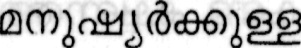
മനുഷ്യര്‍ക്കുള്ള
